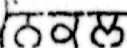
ਨਿਕਲ
